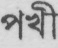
পখী
